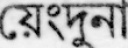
য়েংদুনা
